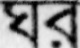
ঘর
